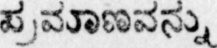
ಪ್ರಮಾಣವನ್ನು
